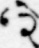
'રે
